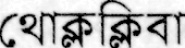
থোক্লক্লিবা
